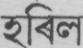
হৰিল
